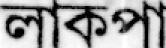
লাকপা
